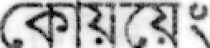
কোয়য়েং
